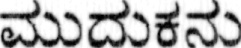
ಮುದುಕನು
